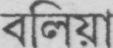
বলিয়া
